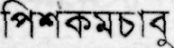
পিশকমচাবু
